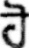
ਹੋ
